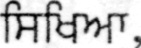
ਸਿਖਿਆ,
